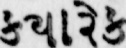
ક્યારેક
